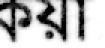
কয়া
